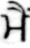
ਮੈਂ
